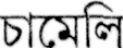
চামেলি
